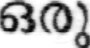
ഒരു
